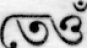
তেওঁ
